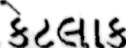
કેટલાક
